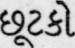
છૂટકો
